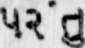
પરંતુ
